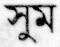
সুম
